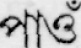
পাওঁ
